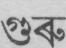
গুৰু
